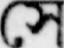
সে
